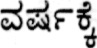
ವರ್ಷಕ್ಕೆ
